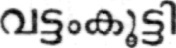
വട്ടംകൂട്ടി
